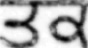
ਤਕ
